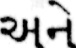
અને
